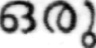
ഒരു
